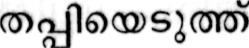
തപ്പിയെടുത്ത്
